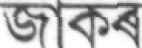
জাকৰ
